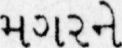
મગરને
